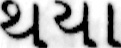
થયા
